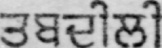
ਤਬਦੀਲੀ
